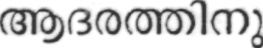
ആദരത്തിനു
